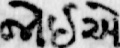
જોઈએ
